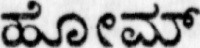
ಹೋಮ್
